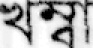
খম্বা
